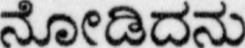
ನೋಡಿದನು
